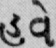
હવે
